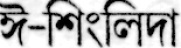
ঈ-শিংলিদা
